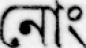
নোং
